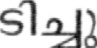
ടിച്ചു
